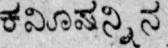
ಕಮಿಷನ್ನಿನ
